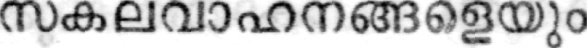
സകലവാഹനങ്ങളെയും
